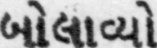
બોલાવ્યો
